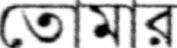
তোমার
